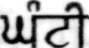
ਘੰਟੀ
